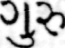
ગુરુ
